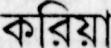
করিয়া
